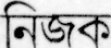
নিজক
